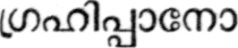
ഗ്രഹിപ്പാനോ
